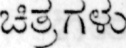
ಚಿತ್ರಗಳು
